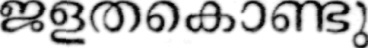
ജളതകൊണ്ടു
